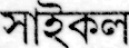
সাইকল
